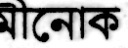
মীনোক
